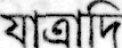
যাত্রদি
